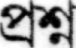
প্রশ্ন
